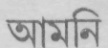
আমনি
